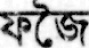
ফজৈ
